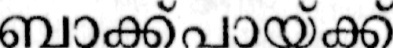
ബാക്ക്പായ്ക്ക്
